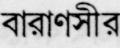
বারাণসীর
